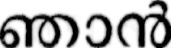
ഞാന്‍
